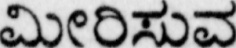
ಮೀರಿಸುವ
